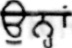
ਉਨ੍ਹਾਂ
